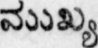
ಮುಖ್ಯ
